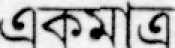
একমাত্র
